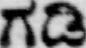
ಗಡಿ
